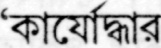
‘কার্যোদ্ধার
